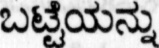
ಬಟ್ಟೆಯನ್ನು
